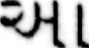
આ
